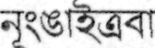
নূংঙাইত্রবা
